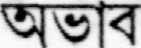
অভাব
